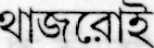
থাজরোই
